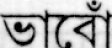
ভাবোঁ
